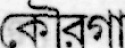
কৌরগা
